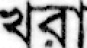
খরা
